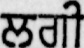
ਲਗੀ
